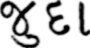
જુદા
